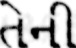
તેની
